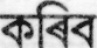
কৰিব
